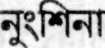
নুংশিনা
